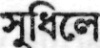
সুধিলে
